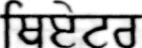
ਥਿਏਟਰ
